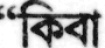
"কিবা
